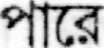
পারে
